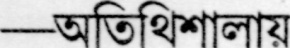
–অতিথিশালায়
